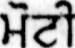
ਮੋਟੀ
